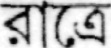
রাত্রে
